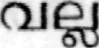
വല്ല
